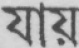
যায়
